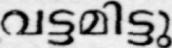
വട്ടമിട്ടു
